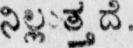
ನಿಲ್ಲುತ್ತದೆ.
